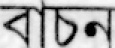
বাচন
